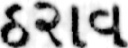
ઠરાવ
